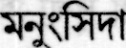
মনুংসিদা
